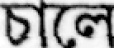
চালে
